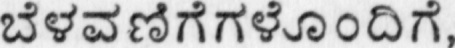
ಬೆಳವಣಿಗೆಗಳೊಂದಿಗೆ,
